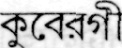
কুবেরগী
